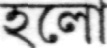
হলো
